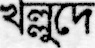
খল্লুদে
